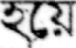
হয়ে
